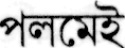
পলমেই
